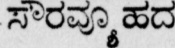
ಸೌರವ್ಯೂಹದ
